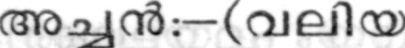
അച്ചന്‍:-(വലിയ
